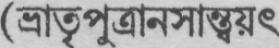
(ভ্ৰাতৃপুত্ৰানসান্ত্বয়ৎ
